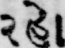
રહો
